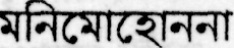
মনিমোহোননা
